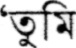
‘তুমি
